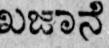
ಖಜಾನೆ
